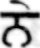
ਨੇ
